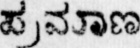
ಪ್ರಮಾಣ
